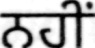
ਨਹੀਂ
